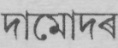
দামোদৰ
